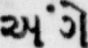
અંગે
